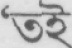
'তই
